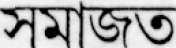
সমাজত
